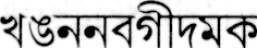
খঙননবগীদমক
